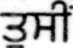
ਤੁਸੀਂ
